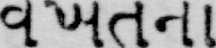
વખતના
